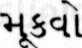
મૂકવો
